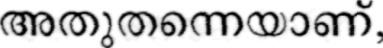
അതുതന്നെയാണ്,
